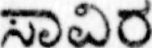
ಸಾವಿರ
